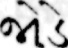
જોડે
